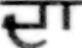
ਦਾ
